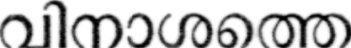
വിനാശത്തെ
